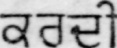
ਕਰਦੀ
